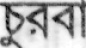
চুরবা
